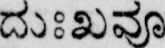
ದುಃಖವೂ
